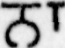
ਨਾ
